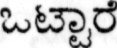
ಒಟ್ಟಾರೆ
